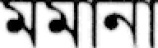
মমানা
